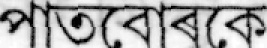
পাতবোৰকে
